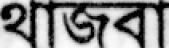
থাজবা
